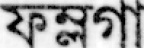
ফম্লগা
